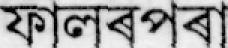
ফালৰপৰা
